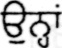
ਉਨ੍ਹਾਂ
